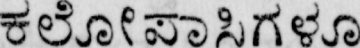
ಕಲೋಪಾಸಿಗಳೂ
